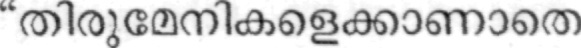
“തിരുമേനികളെക്കാണാതെ
